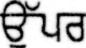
ਉੱਪਰ
